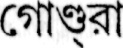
গোণ্ড্রা
